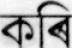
কৰি
